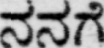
ನನಗೆ
